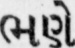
ભણે
